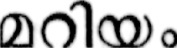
മറിയം
